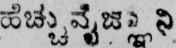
ಹೆಚ್ಚುವೈಜ್ಞಾನಿ
